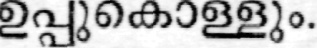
ഉപ്പുകൊള്ളും.
